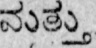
ಮತ್ತು
